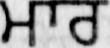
ਮਾਰ
